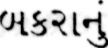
બકરાનું
